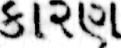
કારણ
